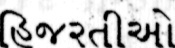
હિજરતીઓ
